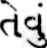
તેવું
